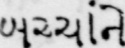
બચ્ચાને
